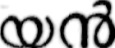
യന്‍
